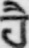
ਹੈ
